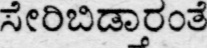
ಸೇರಿಬಿಡ್ತಾರಂತೆ
